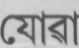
যোৱা
